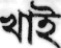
খাই
